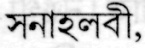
সনাহলবী,
